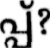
പ്പ്?
